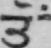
ਤੋਂ
